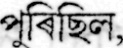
পুৰিছিল,
